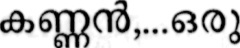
കണ്ണന്‍,...ഒരു
